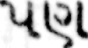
પણ
